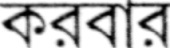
করবার
